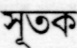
সূতক
